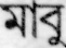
মাবু
